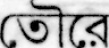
তৌরে
